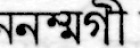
ননম্মগী
